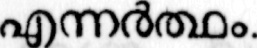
എന്നര്‍ത്ഥം.
